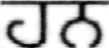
ਹਨ
